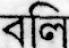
বলি
